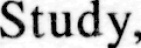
Study,
